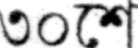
৩০শে
